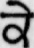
ਕੇ
